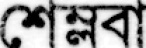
শেম্লবা
